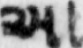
આ
